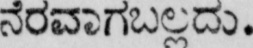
ನೆರವಾಗಬಲ್ಲದು.
